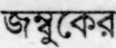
জম্বুকের
